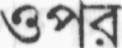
ওপর
